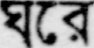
ঘরে
